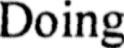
Doing
